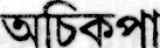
অচিকপা
